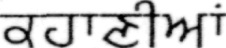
ਕਹਾਣੀਆਂ
